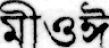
মীওঈ
